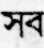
সব
